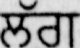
ਲੱਗ
